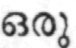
ഒരു
